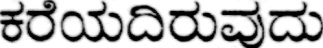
ಕರೆಯದಿರುವುದು
